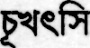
চূখৎসি
